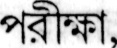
পরীক্ষা,
